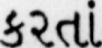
કરતાં
